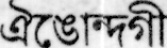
ঐঙোন্দগী
